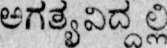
ಅಗತ್ಯವಿದ್ದಲ್ಲಿ
